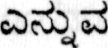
ಎನ್ನುವ
